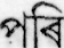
পৰি
